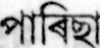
পাৰিছা
